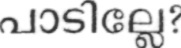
പാടില്ലേ?
